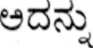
ಅದನ್ನು
